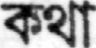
কথা
